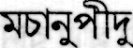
মচানুপীদু
